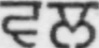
ਵਲ
